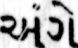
અંગે
